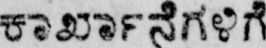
ಕಾರ್ಖಾನೆಗಳಿಗೆ
